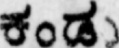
ಕಂಡು
